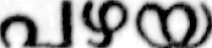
പഴയ
